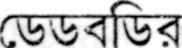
ডেডবডির
